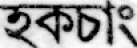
হকচাং
